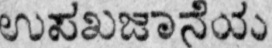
ಉಪಖಜಾನೆಯ
